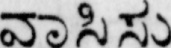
ವಾಸಿಸು
